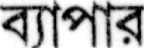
ব্যাপার
